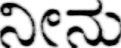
ನೀನು
